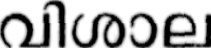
വിശാല
